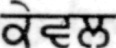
ਕੇਵਲ
